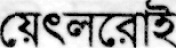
য়েৎলরোই
